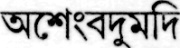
অশেংবদুমদি
